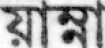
য়াম্না
